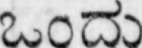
ಒಂದು
